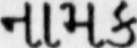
નામક
